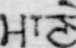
ਮਾਣੇ
